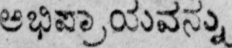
ಅಭಿಪ್ರಾಯವನ್ನು
